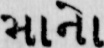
માનો
